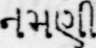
નમણી
